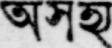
অসহ্য
